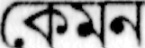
কেমন
